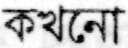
কখনো
